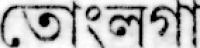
তোংলগা
